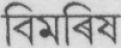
বিমৰিষ
